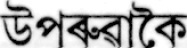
উপৰুৱাকৈ
